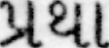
પ્રથા
